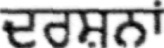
ਦਰਸ਼ਨਾਂ
